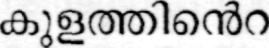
കുളത്തിന്റെ
